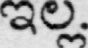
ಇಲ್ಲ.
